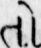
તો
